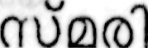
സ്മരി
